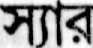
স্যার
